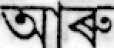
আৰু
